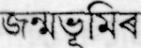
জন্মভূমিৰ
